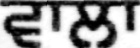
ਵਾਲਾ
